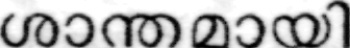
ശാന്തമായി
